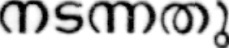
നടന്നതു
